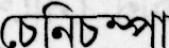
চেনিচম্পা
